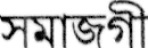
সমাজগী
